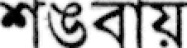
শঙবায়
